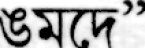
ঙমদে”
